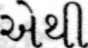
એથી
